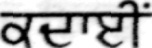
ਕਦਾਈਂ
